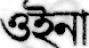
ওইনা
